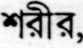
শরীর,
